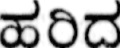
ಹರಿದ
